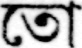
তো
